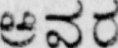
ಅವರ
